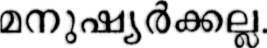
മനുഷ്യര്‍ക്കല്ല.
